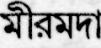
মীরমদা
